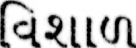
વિશાળ
